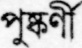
পুষ্কর্ণী
